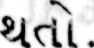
થતો.
